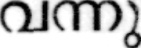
വന്നു
